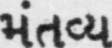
મંતવ્ય
